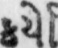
કર્યો
